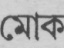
মোক
